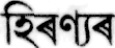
হিৰণ্যৰ
